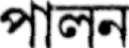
পালন
